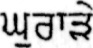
ਘੁਰਾੜੇ
